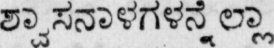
ಶ್ವಾಸನಾಳಗಳನ್ನೆಲ್ಲಾ
